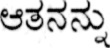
ಆತನನ್ನು
